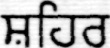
ਸ਼ਹਿਰ
